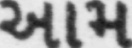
આમ
